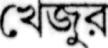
খেজুর
